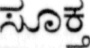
ಸೂಕ್ತ
